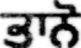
ਭਾਨੋ
